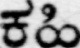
ಕಹಿ
